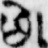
છો
